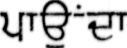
ਪਾਉਂਦਾ
